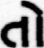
તો
